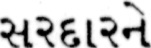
સરદારને
